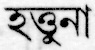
হত্তুনা
